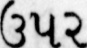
ઉપર
